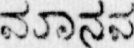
ಮಾನವ
